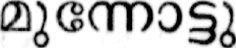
മുന്നോട്ടു
